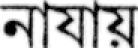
নাযায়
